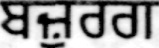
ਬਜ਼ੁਰਗ
